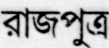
রাজপুত্র
